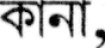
কানা,
